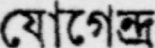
যোগেন্দ্র
